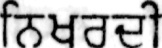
ਨਿਖਰਦੀ
